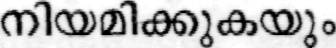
നിയമിക്കുകയും
